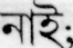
নাই;
